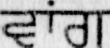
ਵਾਂਗ
